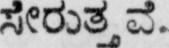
ಸೇರುತ್ತವೆ.
